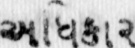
અધિકાર
